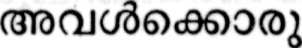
അവള്‍ക്കൊരു
